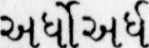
અર્ધોઅર્ધ
